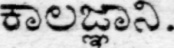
ಕಾಲಜ್ಞಾನಿ.
